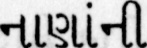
નાણાંની
